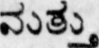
ಮತ್ತು
